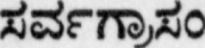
ಸರ್ವಗ್ರಾಸಂ
